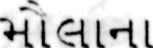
મૌલાના
